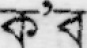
ক'ব
